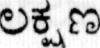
ಲಕ್ಷಣ
